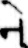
ને
